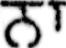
ਨਾ
